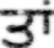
ਤਾਂ
